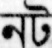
নট
